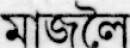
মাজলৈ
